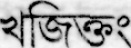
খজিক্তং
